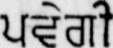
ਪਵੇਗੀ
